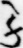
કે
